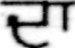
ਦਾ
